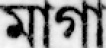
মাগা
